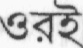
ওরই
